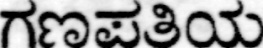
ಗಣಪತಿಯ
